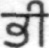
ਭੀ
